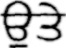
ਉਤੇ
